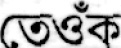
তেওঁক
